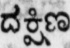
ದಕ್ಷಿಣ
